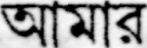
আমার
